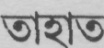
তাহাত
